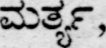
ಮರ್ತ್ಯ,
